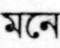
মনে
